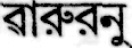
ৱারুরনু
